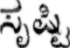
ಸೃಷ್ಟಿ
